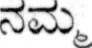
ನಮ್ಮ
